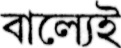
বাল্যেই
